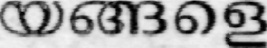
യങ്ങളെ
